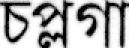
চপ্লগা
